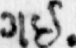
ગઈ.
